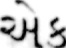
એક
